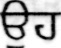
ਉਹ
